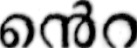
ന്റെ
